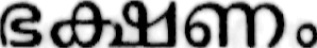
ഭക്ഷണം
